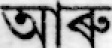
আৰু
